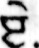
ਏ.
